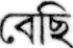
বেছি
